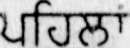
ਪਹਿਲਾਂ
